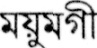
ময়ুমগী
